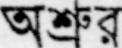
অশ্রুর
